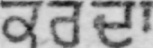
ਕਰਦਾ
